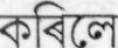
কৰিলে
